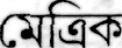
মেত্রিক
